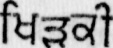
ਖਿੜਕੀ
